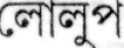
লোলুপ
